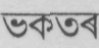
ভকতৰ
